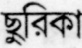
ছুরিকা
